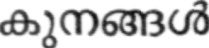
കുനങ്ങള്‍
